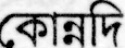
কোন্নদি
